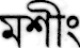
মশীং
